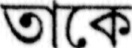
তাকে
